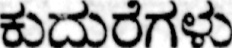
ಕುದುರೆಗಳು
